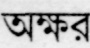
অক্ষর
